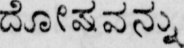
ದೋಷವನ್ನು
